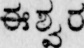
ಈಶ್ವರ
